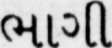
ભાગી
